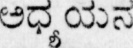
ಅಧ್ಯಯನ
